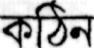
কঠিন
